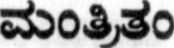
ಮಂತ್ರಿತಂ
